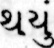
થયું
